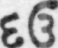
દઉં
